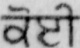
ਕੋਈ
